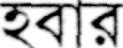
হবার
